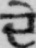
ਦੇ
